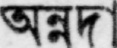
অন্নদা
